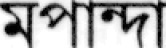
মপান্দা
